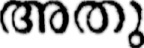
അതു
